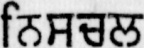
ਨਿਸਚਲ
